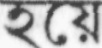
হয়ে
